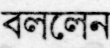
বললেন
